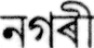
নগৰী
